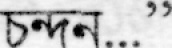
চন্দন..."
